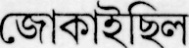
জোকাইছিল
